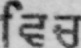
ਵਿਚ
